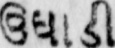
ઉઘાડી
